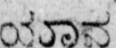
ಯಾವ
